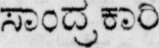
ಸಾಂದ್ರಕಾರಿ
